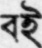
বই
